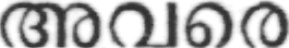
അവരെ
